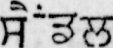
ਸੈਂਡਲ
